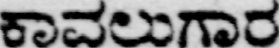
ಕಾವಲುಗಾರ
